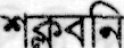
শক্লবনি
